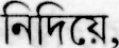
নিদিয়ে,
